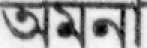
অমনা
